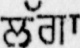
ਲੱਗਾ
